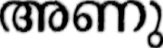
അണു
